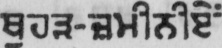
ਥੁਹੜ-ਜ਼ਮੀਨੀਏਂ
